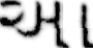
આ
